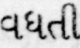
વધતી
